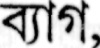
ব্যাগ,
